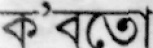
ক'বতো
